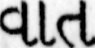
વાત
